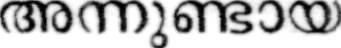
അന്നുണ്ടായ
